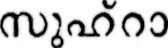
സുഹ്റാ
